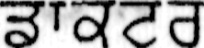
ਡਾਕਟਰ
